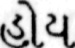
હોય
